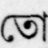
তো
